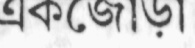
একজোড়া
